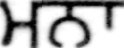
ਮਨਾ
